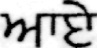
ਆਏ
